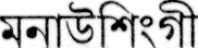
মনাউশিংগী
